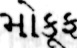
મોકૂફ
